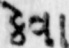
કેવા
